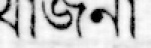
থাজনা
